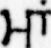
ਮਾਂ
